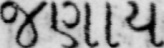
જણાય
